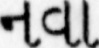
નવા
